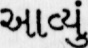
આવ્યું
